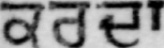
ਕਰਦਾ
